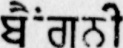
ਬੈਂਗਨੀ
